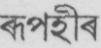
ৰূপহীৰ
